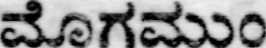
ಮೊಗಮುಂ
